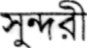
সুন্দরী
